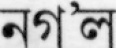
নগ'ল
